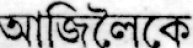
আজিলৈকে
